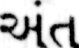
અંત
